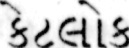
કેટલોક
